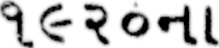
૧૯૨૦ના
